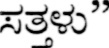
ಸತ್ತಳು"
